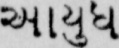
આયુધ
